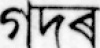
গদৰ
